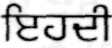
ਇਹਦੀ
